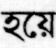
হয়ে
